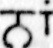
ਨਾਂ
